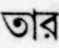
তার
